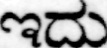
ಇದು
